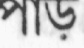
পাড়
